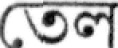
তেল
